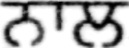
ਨਾਲ
